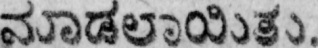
ಮಾಡಲಾಯಿತು.
